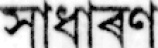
সাধাৰণ
